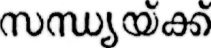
സന്ധ്യയ്ക്ക്
